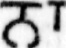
ਨਾ
